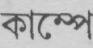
কাম্পে
